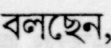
বলছেন,
